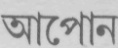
আপোন
